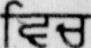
ਵਿਚ
